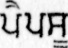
ਪੈਪਸੂ
